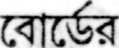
বোর্ডের
